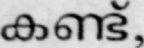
കണ്ട്,
